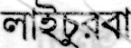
লাইচুরবা
